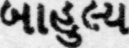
બાહુલ્ય
